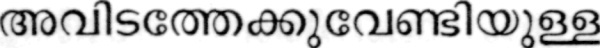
അവിടത്തേക്കുവേണ്ടിയുള്ള
